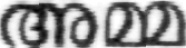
അമ്മ
